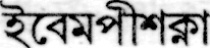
ইবেমপীশক্না
